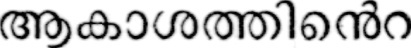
ആകാശത്തിന്റെ
